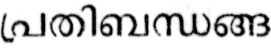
പ്രതിബന്ധങ്ങ
